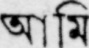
আমি
